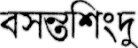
বসন্তশিংদু
